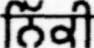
ਨਿੱਕੀ
